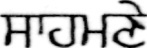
ਸਾਹਮਣੇ
